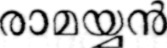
രാമയ്യന്‍
